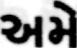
અમે
